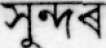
সুন্দৰ
